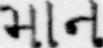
માન
